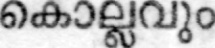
കൊല്ലവും
